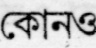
কোনও
